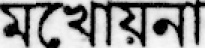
মখোয়না
